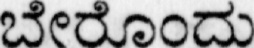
ಬೇರೊಂದು
